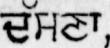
ਦੱਸਣਾ,
